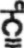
ਨੂੰ
